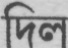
দিল
